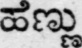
ಹೆಣ್ಣು
